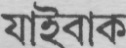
যাইবাক
